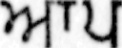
ਆਪ
